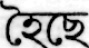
হৈছে
